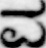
ವ
